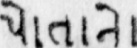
પોતાનો
